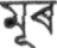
মূৰ
